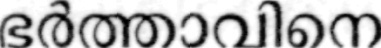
ഭര്‍ത്താവിനെ
